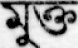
মুক্ত
